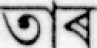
তাৰ
